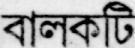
বালকটি
